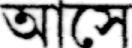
আসে
